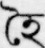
হৈ
